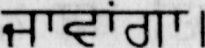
ਜਾਵਾਂਗਾ।
